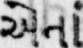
એનાં
